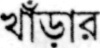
খাঁড়ার
